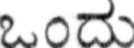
ಒಂದು
